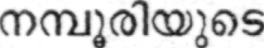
നമ്പൂരിയുടെ
